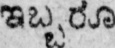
ಇಬ್ಬರೂ
